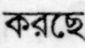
করছে
